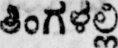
ತಿಂಗಳಲ್ಲಿ
